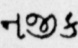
નજીક
